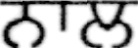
ਨਾਲ
